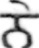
ਨੇ
